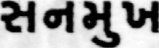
સનમુખ
